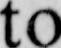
to
